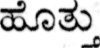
ಹೊತ್ತು
